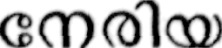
നേരിയ
